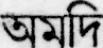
অমদি
